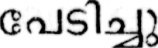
പേടിച്ചു
